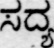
ಸಧ್ಯ
